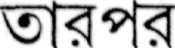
তারপর
